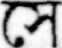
সে
